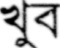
খুব
